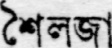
শৈলজা
